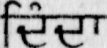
ਦਿੰਦਾ
